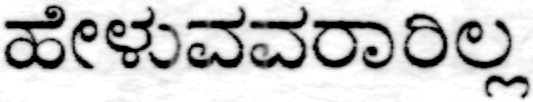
ಹೇಳುವವರಾರಿಲ್ಲ
